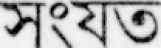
সংযত
